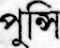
পুন্সি
